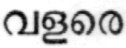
വളരെ
